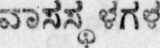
ವಾಸಸ್ಥಳಗಳ
